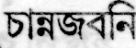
চান্নজবনি
